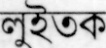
লুইতক
